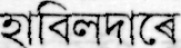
হাবিলদাৰে
